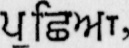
ਪੁਛਿਆ,
